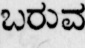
ಬರುವ
